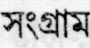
সংগ্রাম
